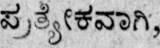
ಪ್ರತ್ಯೇಕವಾಗಿ,
